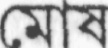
মোষ
